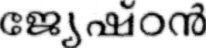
ജ്യേഷ്ഠന്‍
